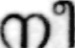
നീ
